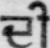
ਦੀ
